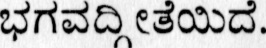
ಭಗವದ್ಗೀತೆಯಿದೆ.
